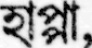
হাপ্পা,
